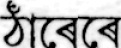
ঠাঁৰেৰে
